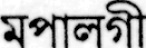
মপালগী
